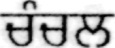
ਚੰਚਲ
